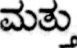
ಮತ್ತು
